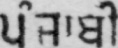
ਪੰਜਾਬੀ
